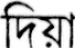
দিয়া
